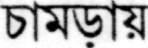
চামড়ায়
